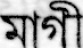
মাগী
